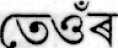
তেওঁৰ
